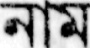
নাম
